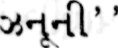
ઝનૂની"
